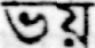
ভয়
